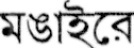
মঙাইরে
